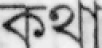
কথা
